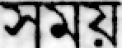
সময়
